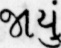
જાયું
